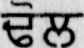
ਢੋਲ
